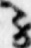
કે
